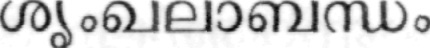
ശൃംഖലാബന്ധം
